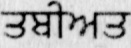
ਤਬੀਅਤ
